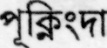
পূক্নিংদা
